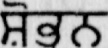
ਸ਼ੋਭਨ
